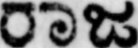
ರಾಜ
